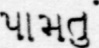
પામતું
